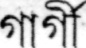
গার্গী
